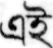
এই
